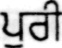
ਪੁਰੀ
